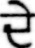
ਦੇ
